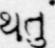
થતું
